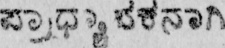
ಪ್ರಾಧ್ಯಾಪಕನಾಗಿ
